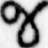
જ
